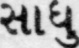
સાધુ
